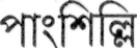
পাংশিল্লি
